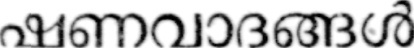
ഷണവാദങ്ങള്‍
